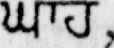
ਘਾਹ,
